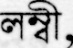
লম্বী,
